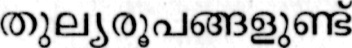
തുല്യരൂപങ്ങളുണ്ട്
